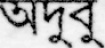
অদুবু
